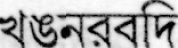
খঙনরবদি
